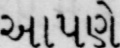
આપણે
